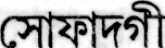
সোফাদগী
